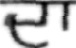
ਦਾ
